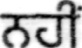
ਨਹੀਂ
